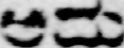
ಅದು
